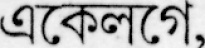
একেলগে,
